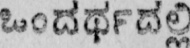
ಒಂದರ್ಥದಲ್ಲಿ
